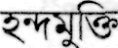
হন্দমুক্তি
